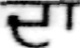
ਦਾ
